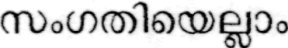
സംഗതിയെല്ലാം
